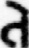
તે
